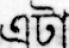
এটা
